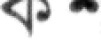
ক
